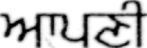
ਆਪਣੀ
